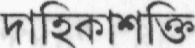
দাহিকাশক্তি
